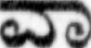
ವಾ
